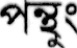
পন্থুং
